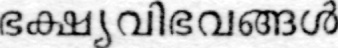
ഭക്ഷ്യവിഭവങ്ങള്‍
